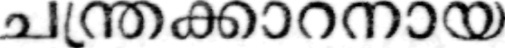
ചന്ത്രക്കാറനായ
